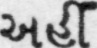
અહીં
